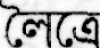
লৈত্রে
